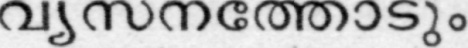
വ്യസനത്തോടും
